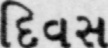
દિવસ
